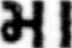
મા
